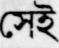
সেই
